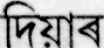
দিয়াৰ
